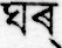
ঘৰ্
